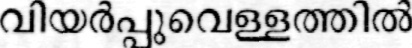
വിയര്‍പ്പുവെള്ളത്തില്‍
